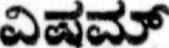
ವಿಷಮ್
